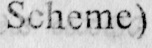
Scheme)
